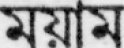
ময়াম
